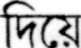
দিয়ে
